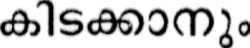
കിടക്കാനും
